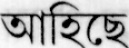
আহিছে
